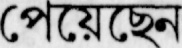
পেয়েছেন
